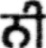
ਨੀ
